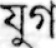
যুগ
